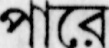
পারে
